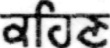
ਕਹਿਣ
